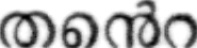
തന്റെ
